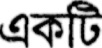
একটি
